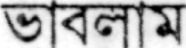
ভাবলাম
